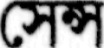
সেন্স
